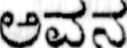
ಅವನ
